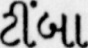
ટીંબા
